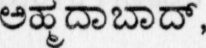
ಅಹ್ಮದಾಬಾದ್,
